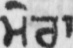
ਮੇਰਾ
